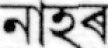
নাহৰ
